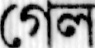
গেল
